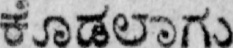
ಕೊಡಲಾಗು
